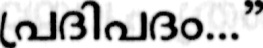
പ്രദിപദം...”
